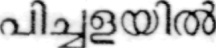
പിച്ചളയില്‍
